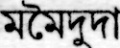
মমৈদুদা
